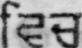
ਵਿਚ
